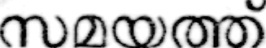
സമയത്ത്
